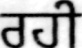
ਰਹੀ
